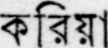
করিয়া
